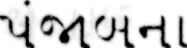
પંજાબના
